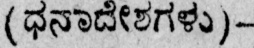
(ಧನಾದೇಶಗಳು)-
